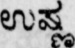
ಉಷ್ಣ
